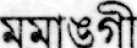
মমাঙগী
